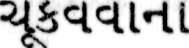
ચૂકવવાના
